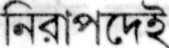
নিরাপদেই
